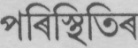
পৰিস্থিতিৰ
